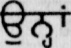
ਉਨ੍ਹਾਂ
